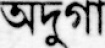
অদুগা
